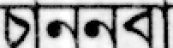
চাননবা
